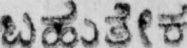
ಬಹುತೇಕ
